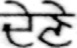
ਦੇਣੇ
